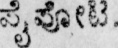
ಪೈಪೋಟಿ.
